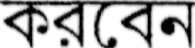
করবেন
